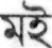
মই
